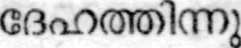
ദേഹത്തിന്നു
